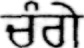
ਚੰਗੇ
